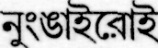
নুংঙাইরোই
